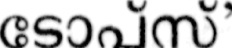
ടോപ്സ്’
